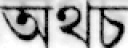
অথচ
